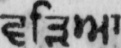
ਵੜਿਆ
